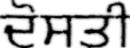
ਦੋਸਤੀ
